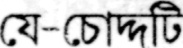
যে-চোদ্দটি
